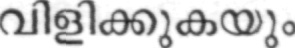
വിളിക്കുകയും
